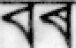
বৰ
